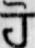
ਹੋ
